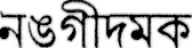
নঙগীদমক
